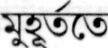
মুহূর্ততে
